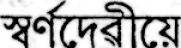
স্বর্ণদেৱীয়ে
